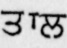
ਤਾਲ
